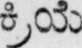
ಕ್ರಿಯೆ
